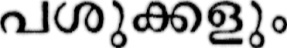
പശുക്കളും
